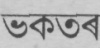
ভকতৰ
